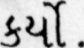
કર્યો.
